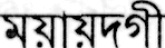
ময়ায়দগী
